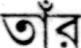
তাঁর
